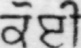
ਕੋਈ
